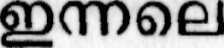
ഇന്നലെ
